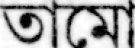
তামো
